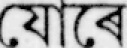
যোৰে
